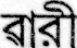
ৱারী
